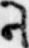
ને
